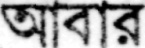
আবার
